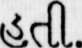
હતી.
